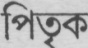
পিতৃক
